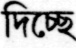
দিচ্ছে
